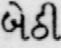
બેઠી
